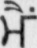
ਮੈਂ
